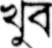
খুব
